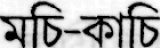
মচি-কাচি
